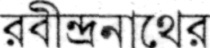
রবীন্দ্রনাথের
